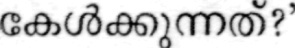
കേള്‍ക്കുന്നത്?’
